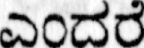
ಎಂದರೆ
